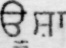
ਊਸ਼ਾ
